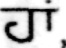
ਹਾਂ,
